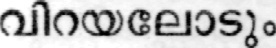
വിറയലോടും
